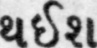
થઈશ
